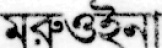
মরুওইনা
